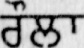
ਰੌਲਾ
